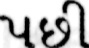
પછી
